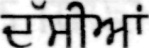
ਦੱਸੀਆਂ
